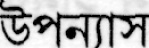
উপন্যাস
